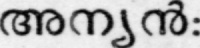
അന്യന്‍:
